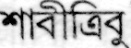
শাবীত্রিবু
